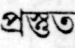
প্রস্তুত
